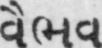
વૈભવ
